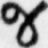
જ
